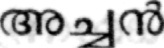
അച്ചന്‍
